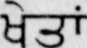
ਖੇਤਾਂ
